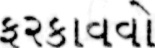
ફરકાવવો
